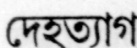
দেহত্যাগ
